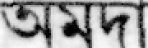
অমদা
